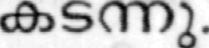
കടന്നു.
